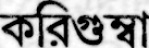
করিগুম্বা
